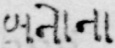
બનોના
